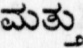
ಮತ್ತು
